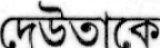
দেউতাকে
